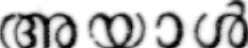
അയാള്‍
